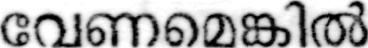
വേണമെങ്കില്‍
